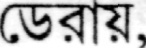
ডেরায়,
